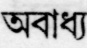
অবাধ্য
